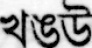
খঙউ
